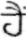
ਹੈਂ
